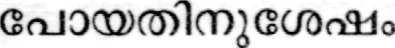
പോയതിനുശേഷം
